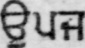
ਉਪਜ
